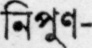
নিপুণ-
